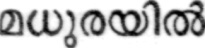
മധുരയില്‍
